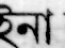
ইনা
